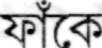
ফাঁকে
